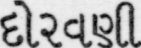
દોરવણી
